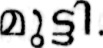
മുട്ടി.
